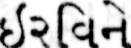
ઇરવિને
